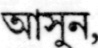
আসুন,
